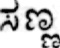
ಸಣ್ಣ
